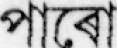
পাৰো
